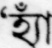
‘হ্যাঁ
